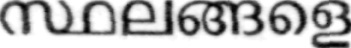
സ്ഥലങ്ങളെ
